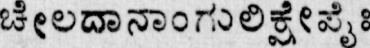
ಚೇಲದಾನಾಂಗುಲಿಕ್ಷೇಪೈಃ
